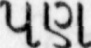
પણ
